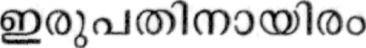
ഇരുപതിനായിരം
